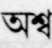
অশ্ব
